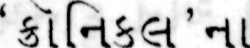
'ક્રૉનિકલ'ના
